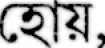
হোয়,
